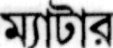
ম্যাটার
